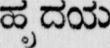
ಹೃದಯ
